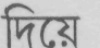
দিয়ে
